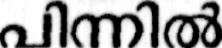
പിന്നില്‍
